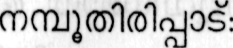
നമ്പൂതിരിപ്പാട്:
